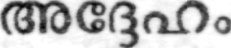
അദ്ദേഹം
